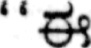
"ಈ
